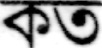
কত
